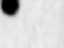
જ
